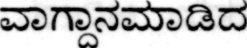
ವಾಗ್ದಾನಮಾಡಿದ
